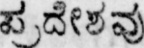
ಪ್ರದೇಶವು
